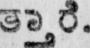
ತ್ತಾರೆ.
